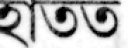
হাতত
